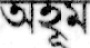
অহূম
